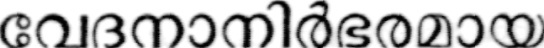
വേദനാനിര്‍ഭരമായ
